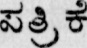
ಪತ್ರಿಕೆ
